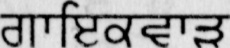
ਗਾਇਕਵਾੜ
